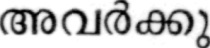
അവര്‍ക്കു
